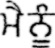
ਮੈਨੂੰ
